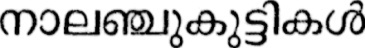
നാലഞ്ചുകുട്ടികള്‍
